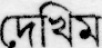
দেখিম
